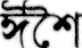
ঈশৈ
